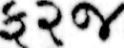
ફરજ
